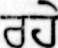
ਰਹੇ
